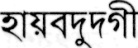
হায়বদুদগী
